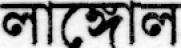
লাঙ্গোল
